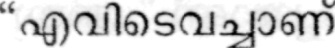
“എവിടെവച്ചാണ്
